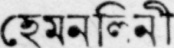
হেমনলিনী
